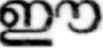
ഈ
